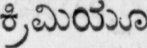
ಕ್ರಿಮಿಯೂ
